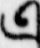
এ
